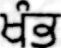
ਖੰਭ
